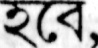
হবে,
